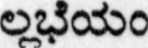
ಲ್ಲಭೆಯಂ
